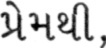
પ્રેમથી,
